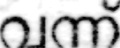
വന്ന്
